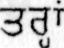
ਤਰ੍ਹਾਂ
